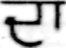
ਦਾ
